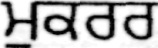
ਮੁਕਰਰ
